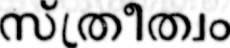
സ്ത്രീത്വം
